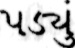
પડ્યું
